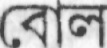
বোল
